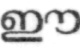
ഈ
